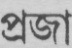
প্ৰজা
